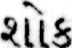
શોક
